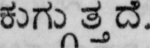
ಕುಗ್ಗುತ್ತದೆ.
